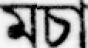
মচা
